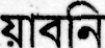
য়াবনি
